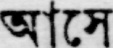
আসে
